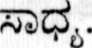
ಸಾಧ್ಯ.
